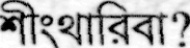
শীংথারিবা?
